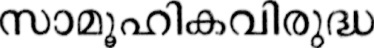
സാമൂഹികവിരുദ്ധ
